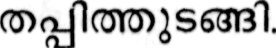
തപ്പിത്തുടങ്ങി.
